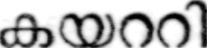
കയററി
